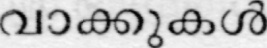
വാക്കുകള്‍
